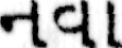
નવા
